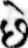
છે
